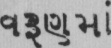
વરૂણમાં
